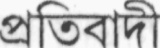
প্রতিবাদী
